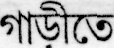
গাড়ীতে
